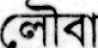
লৌবা
